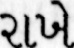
રાખે
